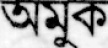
অমুক
